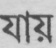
যায়
